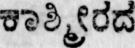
ಕಾಶ್ಮೀರದ
